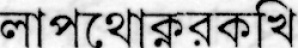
লাপথোক্নরকখি
